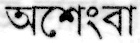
অশেংবা
